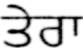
ਤੇਰਾ
